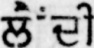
ਲੈਂਦੀ
